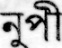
নুপী
